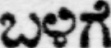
ಬಳಿಗೆ
